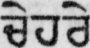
ਚੇਹਰੇ
